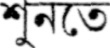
শুনতে
